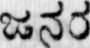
ಜನರ
